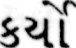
કર્યો
